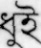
ধুই
